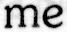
me
